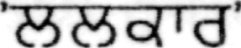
'ਲਲਕਾਰ'
